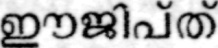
ഈജിപ്ത്
